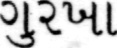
ગુરખા
